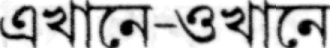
এখানে-ওখানে
